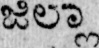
ಜಿಲ್ಲಾ
